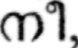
നീ,
